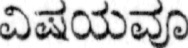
ವಿಷಯವೂ
